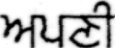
ਆਪਣੀ
